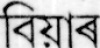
বিয়াৰ
